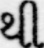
થી
